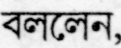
বললেন,
